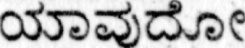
ಯಾವುದೋ
